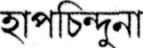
হাপচিন্দুনা
